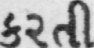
કરતી
